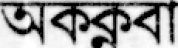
অকক্নবা
